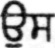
ਉਸ
